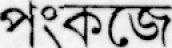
পংকজে
